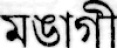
মঙাগী
